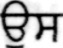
ਉਸ
